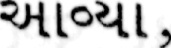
આવ્યા,
